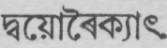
দ্বয়োৰৈক্যাৎ
